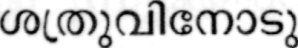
ശത്രുവിനോടു
